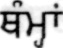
ਥੰਮ੍ਹਾਂ
